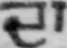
ਦਾ
